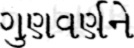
ગુણવર્ણને
